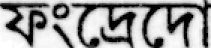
ফংদ্রেদো
